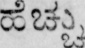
ಹೆಚ್ಚು
